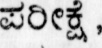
ಪರೀಕ್ಷೆ,
